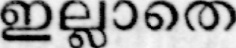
ഇല്ലാതെ
